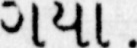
ગયા.
